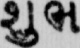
શુભ
